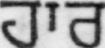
ਹਾਰ
